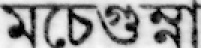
মচেগুম্না
